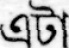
এটা
